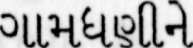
ગામધણીને
